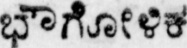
ಭೌಗೋಳಿಕ
